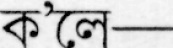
ক'লে-
